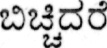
ಬಿಚ್ಚಿದರೆ
